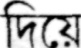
দিয়ে
